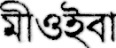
মীওইবা
